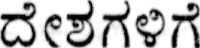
ದೇಶಗಳಿಗೆ
